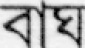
বাঘ
